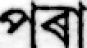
পৰা
